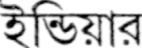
ইন্ডিয়ার
